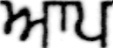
ਆਪ
